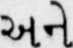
અને
